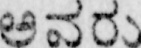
ಅವರು
